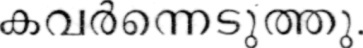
കവര്‍ന്നെടുത്തു.
